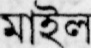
মাইল
